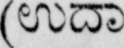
(ಉದಾ
